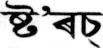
ষ্ট'ৰচ্
